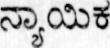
ನ್ಯಾಯಿಕ
